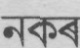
নকৰ
